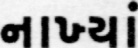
નાખ્યાં
